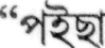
"পইছা
